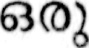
ഒരു
